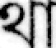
থা
